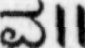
ವ||
